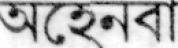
অহেনবা
